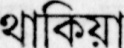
থাকিয়া
